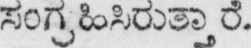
ಸಂಗ್ರಹಿಸಿರುತ್ತಾರೆ.
